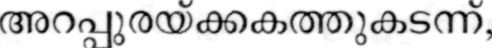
അറപ്പുരയ്ക്കകത്തുകടന്ന്,
